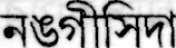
নঙগীসিদা
